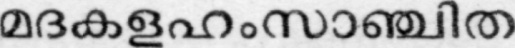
മദകളഹംസാഞ്ചിത
